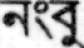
নংবু
